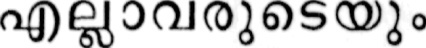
എല്ലാവരുടെയും
